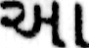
આ
